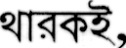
থারকই,
